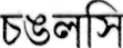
চঙলসি
